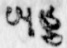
બહુ
